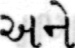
અને
